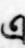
এ
